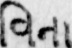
વિના
